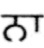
ਨਾ
